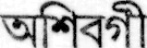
অশিবগী
